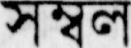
সম্বল
